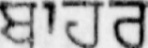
ਬਾਹਰ
